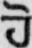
ਹੋ
